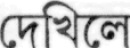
দেখিলে
